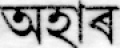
অহাৰ
